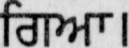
ਗਿਆ।
